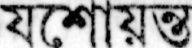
যশোয়ন্ত
